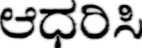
ಆಧರಿಸಿ
